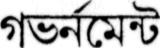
গভর্নমেন্ট
